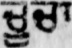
ਚੂਚਾ
